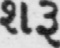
શરૂ
